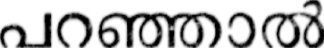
പറഞ്ഞാല്‍
